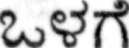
ಒಳಗೆ
